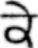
ਕੇ
